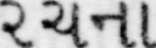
રચના
